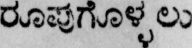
ರೂಪುಗೊಳ್ಳಲು
